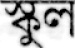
স্কুল
